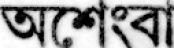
অশেংবা
